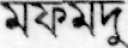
মফমদু
